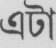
এটা
